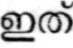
ഇത്
